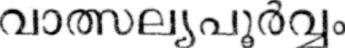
വാത്സല്യപൂര്‍വ്വം
